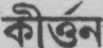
কীৰ্ত্তন
